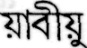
য়াবীয়ু
